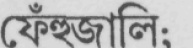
ফেঁহুজালি;
